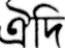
ঐদি
